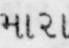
મારા
